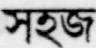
সহজ
